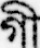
গী
